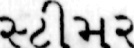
સ્ટીમર
